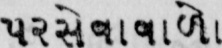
પરસેવાવાળો
